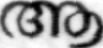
ആ
